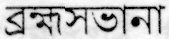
ব্রহ্মসভানা
